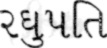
રઘુપતિ
